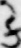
કે
